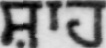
ਸ਼ਾਹ
